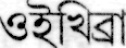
ওইখ্রিব্রা
